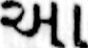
આ
